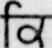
ਕਿ
